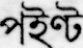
পইণ্ট
